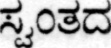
ಸ್ವಂತದ
